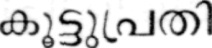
കൂട്ടുപ്രതി
